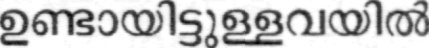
ഉണ്ടായിട്ടുള്ളവയില്‍
